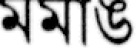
মমাঙ
